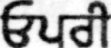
ਓਪਰੀ
